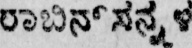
ರಾಬಿನ್‌ಸನ್‌ಳ
